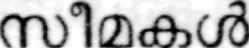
സീമകള്‍
